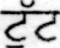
ਟੁੱਟ
